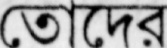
তোদের
